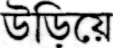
উড়িয়ে
